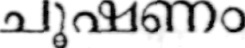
ചൂഷണം
